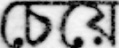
চেয়ে
